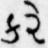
કરે
